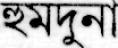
হুমদুনা
